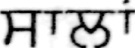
ਸਾਲਾਂ
